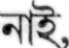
নাই,
